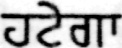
ਹਟੇਗਾ
